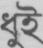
ধুই
